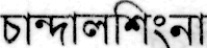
চান্দালশিংনা
